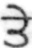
ਤੇ
